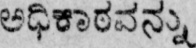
ಅಧಿಕಾರವನ್ನು
